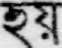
হয়
